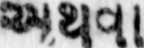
અથવા
